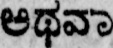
ಅಥವಾ
